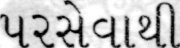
પરસેવાથી
